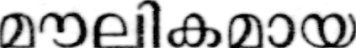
മൌലികമായ
